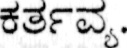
ಕರ್ತವ್ಯ.
